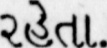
રહેતા.
